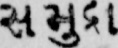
સમુદ્રા
